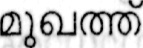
മുഖത്ത്
